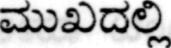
ಮುಖದಲ್ಲಿ
